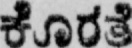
ಕೊರತೆ
